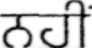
ਨਹੀਂ
